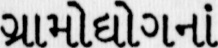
ગ્રામોદ્યોગનાં
